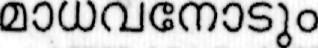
മാധവനോടും
